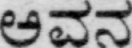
ಅವನ
